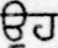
ਉਹ
